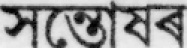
সন্তোষৰ
